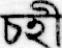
চহী
